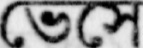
ভেসে
